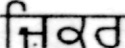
ਜ਼ਿਕਰ
